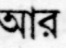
আর
